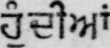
ਹੁੰਦੀਆਂ
